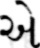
એ
